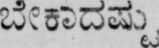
ಬೇಕಾದಷ್ಟು
